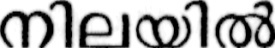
നിലയില്‍
